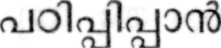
പഠിപ്പിപ്പാന്‍
